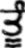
ਤੂੰ
